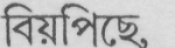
বিয়পিছে,
